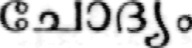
ചോദ്യം
